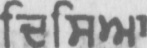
ਦਿਸਿਆ
